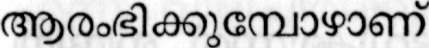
ആരംഭിക്കുമ്പോഴാണ്
